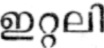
ഇറ്റലി
